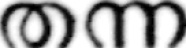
തന്ന
